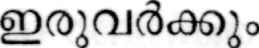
ഇരുവര്‍ക്കും
